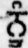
ਨੂੰ
